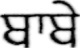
ਬਾਬੇ
